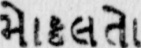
મોકલતો
